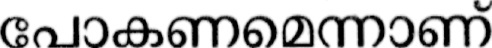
പോകണമെന്നാണ്
